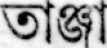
তাঞ্জা
